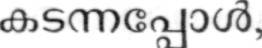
കടന്നപ്പോള്‍,
